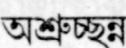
অশ্রুচ্ছন্ন
